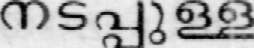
നടപ്പുള്ള
